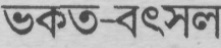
ভকত-বৎসল
